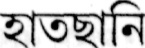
হাতছানি
